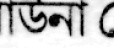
লাউনা
